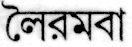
লৈরমবা
